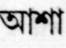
আশা
